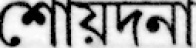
শোয়দনা
